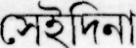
সেইদিনা
